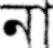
না
